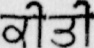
ਕੀਤੀ
